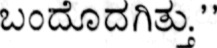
ಬಂದೊದಗಿತ್ತು."
